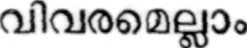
വിവരമെല്ലാം
